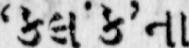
'કલંક'ના
